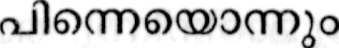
പിന്നെയൊന്നും
